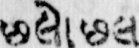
છલોછલ
